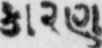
,કારણ
